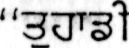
''ਤੁਹਾਡੀ
